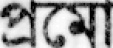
প্রমো
